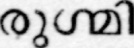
രുഗ്മി
